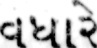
વધારે
